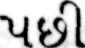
પછી
